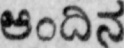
ಅಂದಿನ
